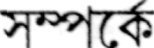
সম্পর্কে
